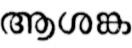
ആശങ്ക
